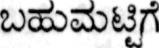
ಬಹುಮಟ್ಟಿಗೆ
